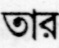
তার
